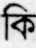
কি
